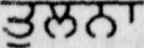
ਤੁਲਨਾ
